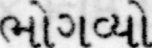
ભોગવ્યો
